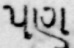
પણ
